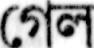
গেল
